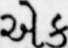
એક
